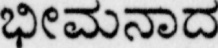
ಭೀಮನಾದ
